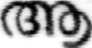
ആ
